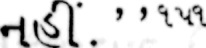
નહીં."૧૫૧
